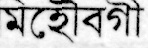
মিহৌবগী
